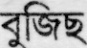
বুজিছ
